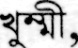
খুম্মী,
